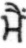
ਮੈਂ
